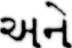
અને
